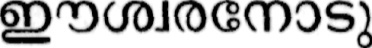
ഈശ്വരനോടു
